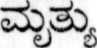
ಮೃತ್ಯು
